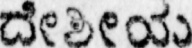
ದೇಶೀಯ
